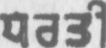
ਧਰਤੀ
